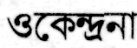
ওকেন্দ্রনা
